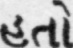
હતો
